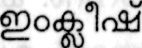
ഇംക്ലീഷ്
